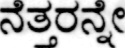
ನೆತ್ತರನ್ನೇ
